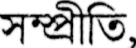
সম্প্রীতি,
